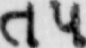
તપ
